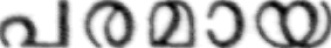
പരമായ
